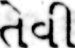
તેવી
